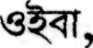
ওইবা,
